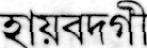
হায়বদগী
